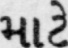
માટે
